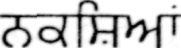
ਨਕਸ਼ਿਆਂ
